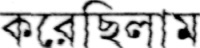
করেছিলাম
